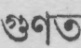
গুণত
